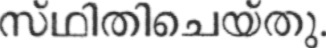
സ്ഥിതിചെയ്തു.
